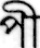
পী
